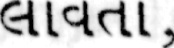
લાવતા,
